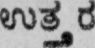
ಉತ್ತರ
